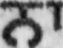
ਨਾ
